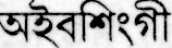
অইবশিংগী
